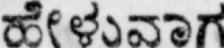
ಹೇಳುವಾಗ
